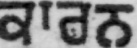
ਕਾਰਨ
